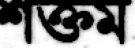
শক্তম
